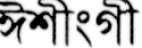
ঈশীংগী
